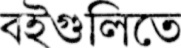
বইগুলিতে
